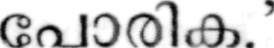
പോരിക.'
